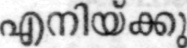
എനിയ്ക്കു
